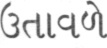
ઉતાવળે
